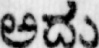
ಅದು
